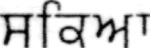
ਸਕਿਆ
